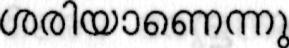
ശരിയാണെന്നു
